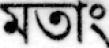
মতাং
